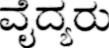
ವೈದ್ಯರು
